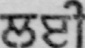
ਲਈ
